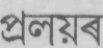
প্ৰলয়ৰ
